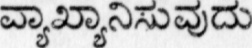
ವ್ಯಾಖ್ಯಾನಿಸುವುದು
